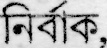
নির্বাক,
